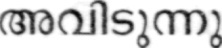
അവിടുന്നു
